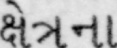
ક્ષેત્રના
